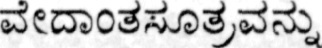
ವೇದಾಂತಸೂತ್ರವನ್ನು
